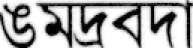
ঙমদ্রবদা
